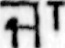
ਜਾ
